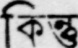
কিন্তু
